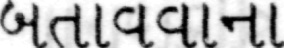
બતાવવાના
